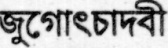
জুগোৎচাদবী
